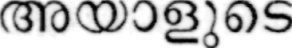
അയാളുടെ
